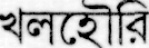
খলহৌরি
